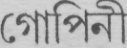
গোপিনী
